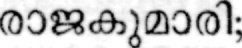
രാജകുമാരി;
